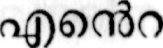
എന്റെ
